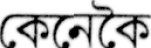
কেনেকৈ
